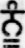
ਨੂੰ
